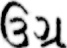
ઉગ્ર
